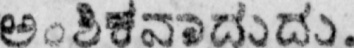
ಅಂಶಿಕವಾದುದು.
